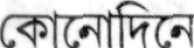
কোনোদিনে
